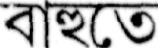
বাহুতে
